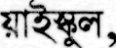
সাইস্কুল,
